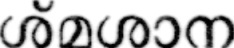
ശ്മശാന
